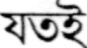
যতই
